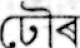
টোৰ
